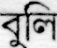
বুলি
